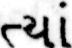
ત્યાં
